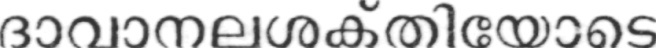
ദാവാനലശക്തിയോടെ
